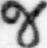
જ
